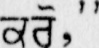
ਕਰੋ,''
